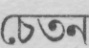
চেতন
